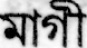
মাগী
